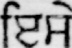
ਇਸੇ
